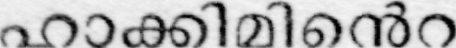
ഹാക്കിമിന്റെ
